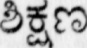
ಶಿಕ್ಷಣ
